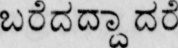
ಬರೆದದ್ದಾದರೆ
